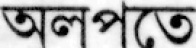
অলপতে
